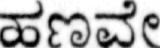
ಹಣವೇ
